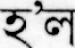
হ'ল
